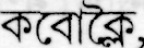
কবোক্লৈ,
